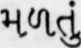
મળતું
